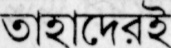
তাহাদেরই
